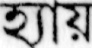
হ্যায়
